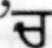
'ਚ
